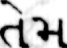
તેમ
